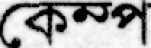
কেম্প
